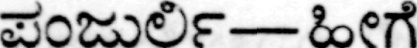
ಪಂಜುರ್ಲಿ-ಹೀಗೆ
